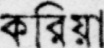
করিয়া
